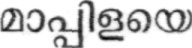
മാപ്പിളയെ
